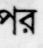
পর
